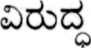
ವಿರುದ್ಧ
